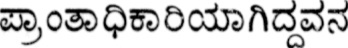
ಪ್ರಾಂತಾಧಿಕಾರಿಯಾಗಿದ್ದವನ
